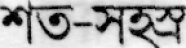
শত-সহস্র
